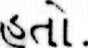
હતો.
